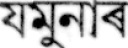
যমুনাৰ
